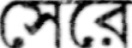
সেরে
